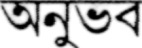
অনুভব
